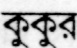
কুকুর
